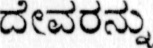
ದೇವರನ್ನು
